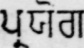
ਪ੍ਰਯੋਗ
